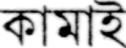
কামাই
